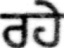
ਰਹੇ
